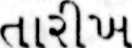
તારીખ
